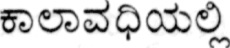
ಕಾಲಾವಧಿಯಲ್ಲಿ
